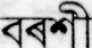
বৰশী
